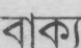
বাক্য
